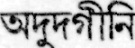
অদুদগীনি
